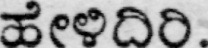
ಹೇಳಿದಿರಿ.
